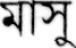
মাসু
